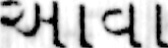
આવા
